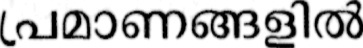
പ്രമാണങ്ങളില്‍
